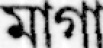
মাগা
